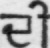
ਦੀ
